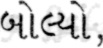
બોલ્યો,
